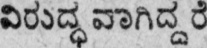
ವಿರುದ್ಧವಾಗಿದ್ದರೆ
